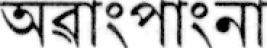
অৱাংপাংনা
